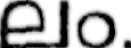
ലം.
